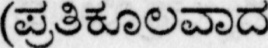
(ಪ್ರತಿಕೂಲವಾದ
